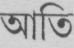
আতি
